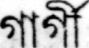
গার্গী
